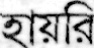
হায়রি
